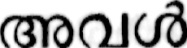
അവള്‍
